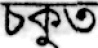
চকুত
